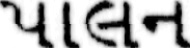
પાલન
